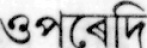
ওপৰেদি
